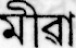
মীৱা
